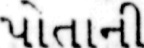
પોતાની
